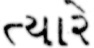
ત્યારે
